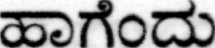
ಹಾಗೆಂದು
